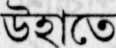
উহাতে
